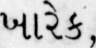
ખારેક,
